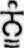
ਨੂੰ
